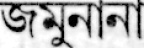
জমুনানা
